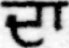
ਦਾ
